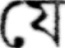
যে
